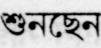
শুনছেন
